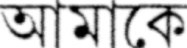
আমাকে
